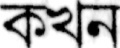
কখন
